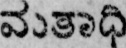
ಮತಾಧಿ
